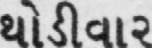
થોડીવાર
